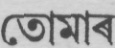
তোমাৰ
